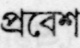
প্রবেশ
